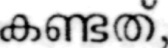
കണ്ടത്,
